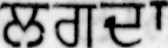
ਲਗਦਾ
